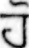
ਹੋ
